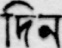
দিন
